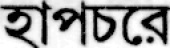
হাপচরে
